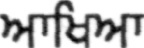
ਆਖਿਆ
